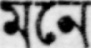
মনে
